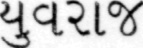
યુવરાજ
